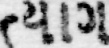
ત્યાગ
